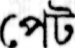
পেট
